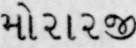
મોરારજી
